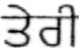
ਤੇਰੀ
